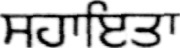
ਸਹਾਇਤਾ
